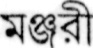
মঞ্জরী
